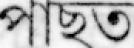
পাছত
